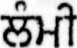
ਲੰਮੀ
